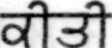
ਕੀਤੀ
